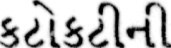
કટોકટીની
